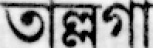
তাল্লগা
